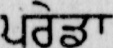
ਪਰੇਡਾ
